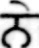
ਨੇ
